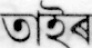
তাইৰ
